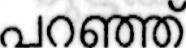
പറഞ്ഞ്
